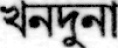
খনদুনা
